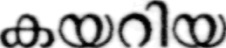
കയറിയ
